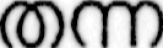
തന്ന
